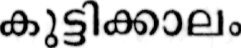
കുട്ടിക്കാലം
